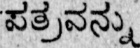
ಪತ್ರವನ್ನು
